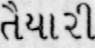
તૈયારી
